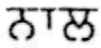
ਨਾਲ
